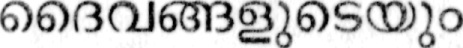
ദൈവങ്ങളുടെയും
